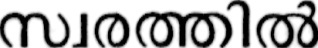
സ്വരത്തില്‍
